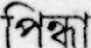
পিন্ধা
